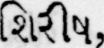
શિરીષ,
